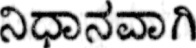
ನಿಧಾನವಾಗಿ
